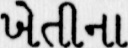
ખેતીના
